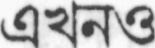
এখনও
